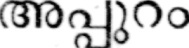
അപ്പുറം
